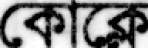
কোক্লে
